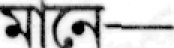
মানে-
